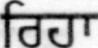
ਰਿਹਾ
